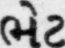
ભેટ
